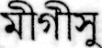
মীগীসু
